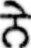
ਨੇ
